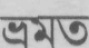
ভ্ৰমত
